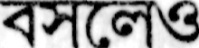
বসলেও
